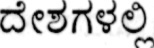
ದೇಶಗಳಲ್ಲಿ
